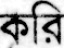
করি
